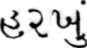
હરખું
